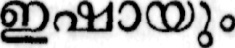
ഇഷായും
